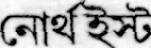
নোর্থইস্ট
